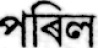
পৰিল
